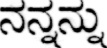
ನನ್ನನ್ನು
